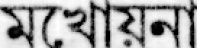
মখোয়না
